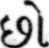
છો
